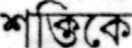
শক্তিকে
